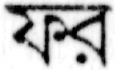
ফর
